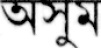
অসুম
